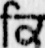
ਕਿ
